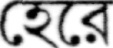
হেরে
